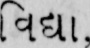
વિધા,
